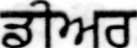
ਡੀਅਰ
